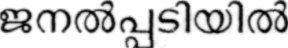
ജനല്‍പ്പടിയില്‍
